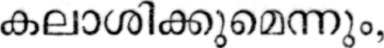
കലാശിക്കുമെന്നും,
